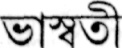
ভাস্বতী
